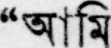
‘‘আমি
